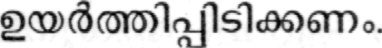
ഉയര്‍ത്തിപ്പിടിക്കണം.
